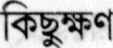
কিছুক্ষণ
